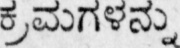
ಕ್ರಮಗಳನ್ನು
